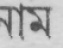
নাম
